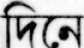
দিনে
